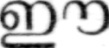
ഈ
